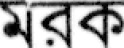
মরক
